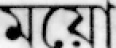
ময়ো
